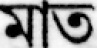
মাত
